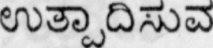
ಉತ್ಪಾದಿಸುವ
